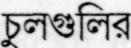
চুলগুলির
